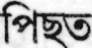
পিছত
